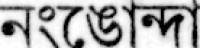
নঙোন্দা
